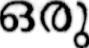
ഒരു
